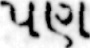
પણ
